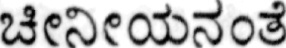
ಚೀನೀಯನಂತೆ
